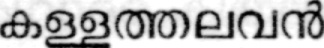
കള്ളത്തലവന്‍
